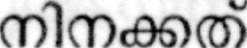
നിനക്കത്
